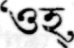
‘ওহ্,
